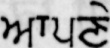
ਆਪਣੇ
